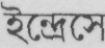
ইন্দ্ৰেসে
